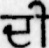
ਦੀ
